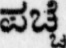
ಪಚ್ಚೆ
